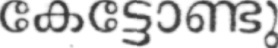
കേട്ടോണ്ടു
